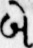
બે
